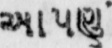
આપણું
